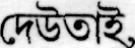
দেউতাই,
